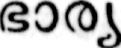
ഭാര്യ
